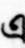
এ
